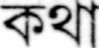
কথা
